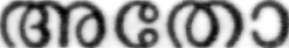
അതോ
